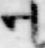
ન
